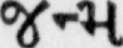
જન્મ
